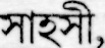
সাহসী,
